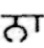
ਨਾ
